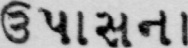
ઉપાસના
